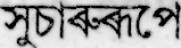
সুচাৰুৰূপে
